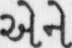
એને
